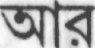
আর
